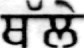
ਥੱਲੇ
